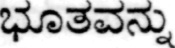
ಭೂತವನ್ನು
